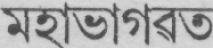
মহাভাগৱত
